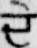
ਦੇ
